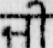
ਜੀ
